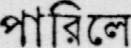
পারিলে
